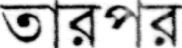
তারপর
